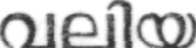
വലിയ
